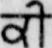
ਕੀ
